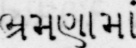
ભમણામાં
